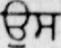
ਉਸ
